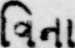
વિના
